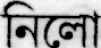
নিলো
